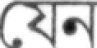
যেন
